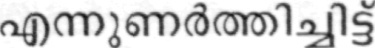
എന്നുണര്‍ത്തിച്ചിട്ട്
